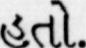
હતો.
